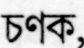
চণক,
